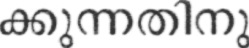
ക്കുന്നതിനു
